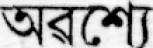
অৱশ্যে
